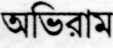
অভিরাম
